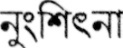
নুংশিৎনা
